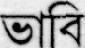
ভাবি
